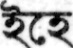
ইহে
